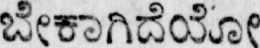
ಬೇಕಾಗಿದೆಯೋ
